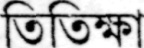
তিতিক্ষা
